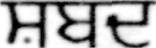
ਸ਼ਬਦ
